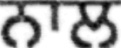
ਨਾਲ
